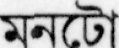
মনটো
